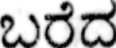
ಬರೆದ
